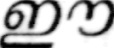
ഈ
